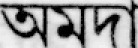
অমদা
